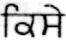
ਕਿਸੇ
